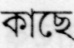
কাছে
